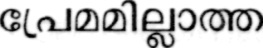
പ്രേമമില്ലാത്ത
